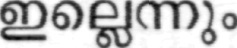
ഇല്ലെന്നും
